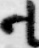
ન
